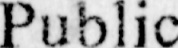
Public
